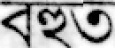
বহুত
